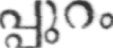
പ്പുറം
